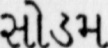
સોડમ
